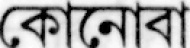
কোনোবা
